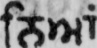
ਨਿਆਂ
